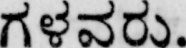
ಗಳವರು.
